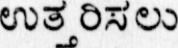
ಉತ್ತರಿಸಲು
